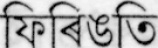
ফিৰিঙতি
